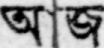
আজ
